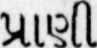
પ્રાણી
